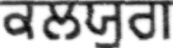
ਕਲਯੁਗ
